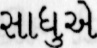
સાધુએ
